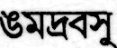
ঙমদ্রবসু
